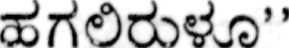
ಹಗಲಿರುಳೂ"
